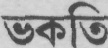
ভকতি
